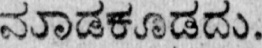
ಮಾಡಕೂಡದು.
